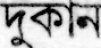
দুকান
